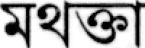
মথক্তা
